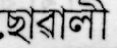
ছোৱালী
